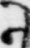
ને
